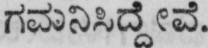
ಗಮನಿಸಿದ್ದೇವೆ.
